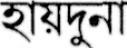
হাযদুনা
